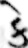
કે
